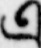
এ
